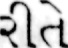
રીતે
